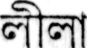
লীলা
